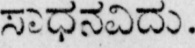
ಸಾಧನವಿದು.
